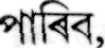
পাৰিব,
